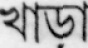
খাড়া
